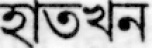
হাতখন
